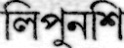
লিপুনশি
